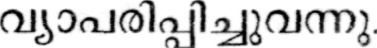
വ്യാപരിപ്പിച്ചുവന്നു.
